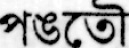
পঙতৌ
